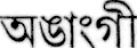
অঙাংগী
